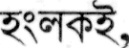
হংলকই,
